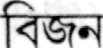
বিজন
